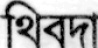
থিবদা
